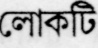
লোকটি
